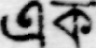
এক
